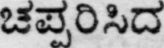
ಚಪ್ಪರಿಸಿದ
